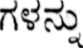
ಗಳನ್ನು
